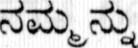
ನಮ್ಮನ್ನು
